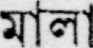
মালা
